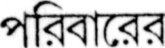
পরিবারের
